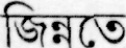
জিন্নতে
